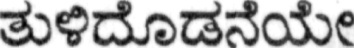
ತುಳಿದೊಡನೆಯೇ
